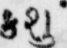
કશું
